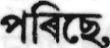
পৰিছে,
